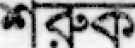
শরুক
